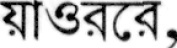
য়াওররে,
